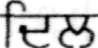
ਦਿਲ
